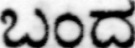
ಬಂದ
